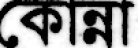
কোন্না
